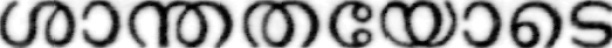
ശാന്തതയോടെ
